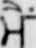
ਮੈਂ
